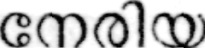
നേരിയ
